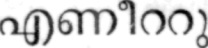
എണീററു
